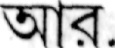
আর.
